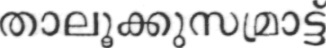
താലൂക്കുസമ്രാട്ട്
